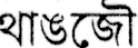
থাঙজৌ
